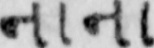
નાના
